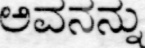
ಅವನನ್ನು
